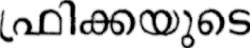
ഫ്രിക്കയുടെ
